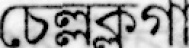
চেল্লক্লগা
